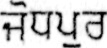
ਜੋਧਪੁਰ
